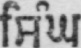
ਸਿੰਘ
